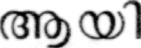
ആയി
